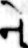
ને
